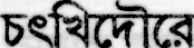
চৎখিদৌরে
